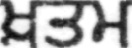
ਖ਼ਤਮ
